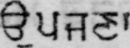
ਉਪਜਣਾ
